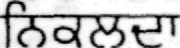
ਨਿਕਲਦਾ
